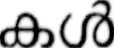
കള്‍
